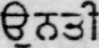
ਉਨਤੀ
